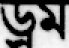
ড্রম
